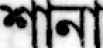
শানা
